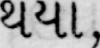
થયા,
